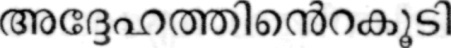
അദ്ദേഹത്തിന്റെകൂടി
